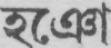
হঞো
